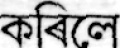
কৰিলে
